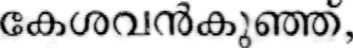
കേശവന്‍കുഞ്ഞ്,
